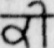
ਕੀ
